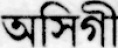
অসিগী
